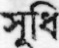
সুধি
